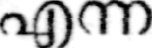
എന്ന
